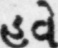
હવે
